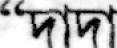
“দাদা
